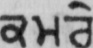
ਕਮਰੇ
